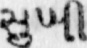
સુખી
